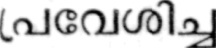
പ്രവേശിച്ച
